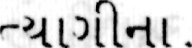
ત્યાગીના.
